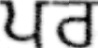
ਪਰ
